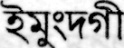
ইমুংদগী
